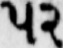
પર
